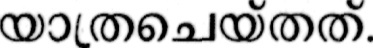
യാത്രചെയ്തത്.
